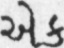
એક
